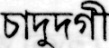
চাদুদগী
